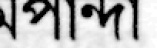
মপান্দা
